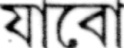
যাবো
